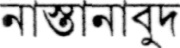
নাস্তানাবুদ
